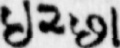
ઈચ્છા
